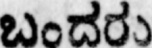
ಬಂದರು
